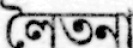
লৈতনা
